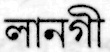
লানগী
